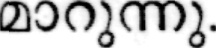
മാറുന്നു.
